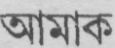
আমাক
